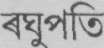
ৰঘুপতি
